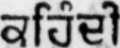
ਕਹਿੰਦੀ
